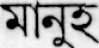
মানুহ
